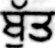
ਬੁੱਤ
